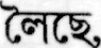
লৈছে,
